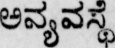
ಅವ್ಯವಸ್ಥೆ
